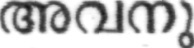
അവനു
